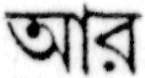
আর
